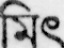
মিৎ
